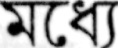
মধ্যে
